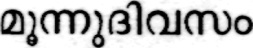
മൂന്നുദിവസം
